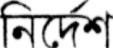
নির্দেশ
